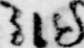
કોઈ
